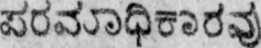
ಪರಮಾಧಿಕಾರವು
